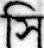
সি
